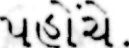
પહોંચે.
